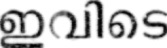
ഇവിടെ
